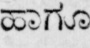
ಹಾಗೂ
